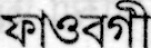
ফাওবগী
